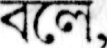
বলে,
